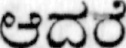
ಆದರೆ
